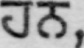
ਹਨ,
